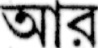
আর
